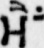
ਮੈਂ
